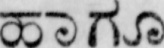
ಹಾಗೂ
